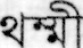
থম্মী
